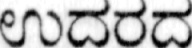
ಉದರದ
